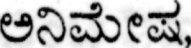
ಅನಿಮೇಷ,
